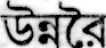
উন্নরৈ
